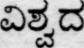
ವಿಶ್ವದ
